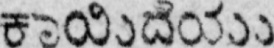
ಕಾಯಿದೆಯು
